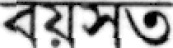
বয়সত
